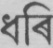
ধৰি
